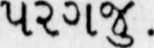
પરગજુ.
